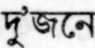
দু’জনে
